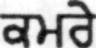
ਕਮਰੇ
